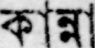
কান্না
